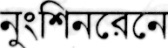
নুংশিনরেনে
